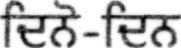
ਦਿਨੋ-ਦਿਨ
